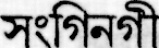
সংগিনগী
